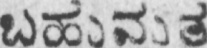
ಬಹುಮತ
